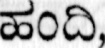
ಹಂದಿ,
